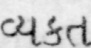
વ્યકત
